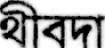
থীবদা
